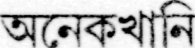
অনেকখানি
